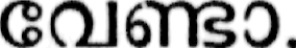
വേണ്ടാ.
